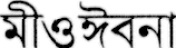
মীওঈবনা
